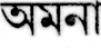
অমনা
